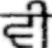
ਵੀ
